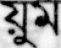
য়ুম
